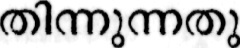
തിന്നുന്നതു
